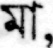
মা,
